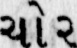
ચોર
